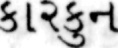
કારકુન
